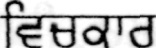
ਵਿਚਕਾਰ
